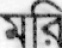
মরি
